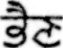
ਭੈਣ
